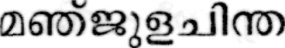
മഞ്ജുളചിന്ത
